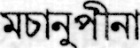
মচানুপীনা
